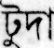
টুদা
